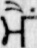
ਮੈਂ
